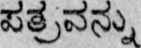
ಪತ್ರವನ್ನು
